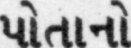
પોતાનો
